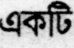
একঢি
